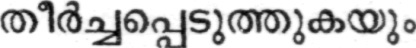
തീര്‍ച്ചപ്പെടുത്തുകയും
